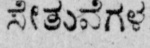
ಸೇತುವೆಗಳ
